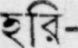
হরি-
